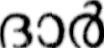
ദാര്‍
